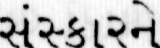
સંસ્કારને
